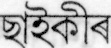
ছাইকীৰ
